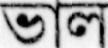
ভাল
